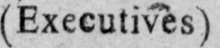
(Executives)
